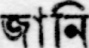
জানি
